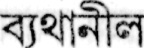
ব্যথানীল
